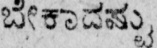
ಬೇಕಾದಷ್ಟು
